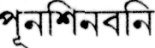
পূনশিনবনি
